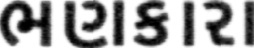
ભણકારા
